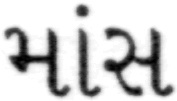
માંસ
